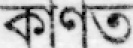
কাণত
